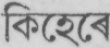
কিহেৰে
